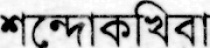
শন্দোকখিবা
